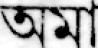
অমা
